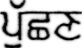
ਪੁੱਛਣ
